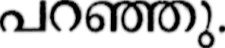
പറഞ്ഞു.
